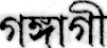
গঙ্গাগী
